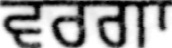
ਵਰਗਾ
